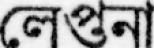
লেপ্তনা
